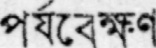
পর্যবেক্ষণ
